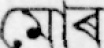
মোৰ
